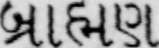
બ્રાહ્મણ
